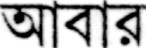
আবার
